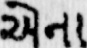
એના
